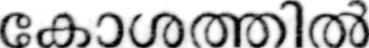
കോശത്തില്‍
